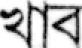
খাব
